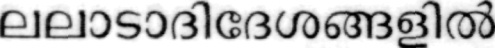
ലലാടാദിദേശങ്ങളില്‍
